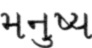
મનુષ્ય
